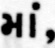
માં,
